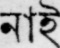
নাই
